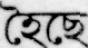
হৈছে
